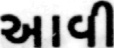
આવી
